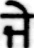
ਜੇ
